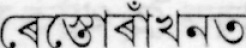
ৰেস্তোৰাঁখনত
